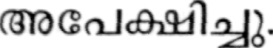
അപേക്ഷിച്ചു.
